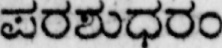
ಪರಶುಧರಂ
